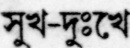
সুখ-দুঃখে
